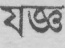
যজ্ঞ
